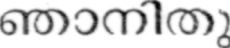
ഞാനിതു
